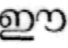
ഈ
